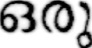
ഒരു
